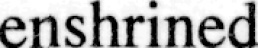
enshrined
